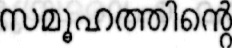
സമൂഹത്തിന്റെ
